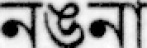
নঙনা
